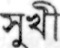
সুখী
